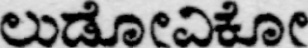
ಲುಡೋವಿಕೋ
